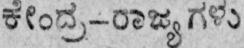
ಕೇಂದ್ರ-ರಾಜ್ಯಗಳು
